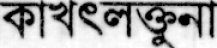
কাখৎলক্তুনা
